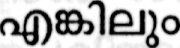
എങ്കിലും
